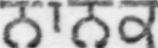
ਨਾਨਕ
